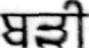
ਬੜੀ
